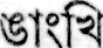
ঙাংখি
